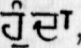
ਹੁੰਦਾ,
